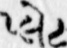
પ્લેટ
